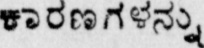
ಕಾರಣಗಳನ್ನು
